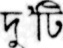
দু'টি
